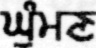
ਘੁੰਮਣ
